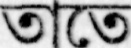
তাতে
